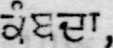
ਕੰਬਦਾ,
